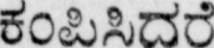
ಕಂಪಿಸಿದರೆ
